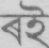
ৰই
